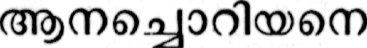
ആനച്ചൊറിയനെ
